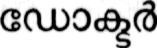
ഡോക്ടര്‍
